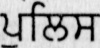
ਪੁਲਿਸ
